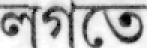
লগতে
